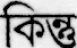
কিন্তু
